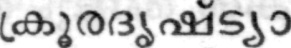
ക്രൂരദൃഷ്ട്യാ
